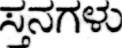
ಸ್ತನಗಳು
